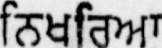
ਨਿਖਰਿਆ
